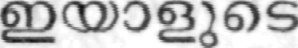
ഇയാളുടെ
